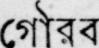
গৌরব
